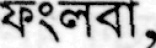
ফংলবা,
